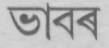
ভাবৰ
